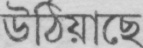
উঠিয়াছে
